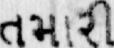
તમારી
